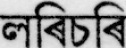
লৰিচৰি
